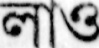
লাও
